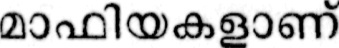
മാഫിയകളാണ്
